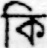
কি
